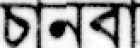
চানবা
